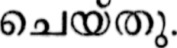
ചെയ്തു.
